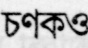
চণকও
